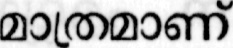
മാത്രമാണ്
